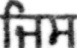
ਜਿਸ
